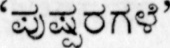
‘ಪುಷ್ಪರಗಳೆ’
